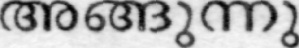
അങ്ങുന്നു
